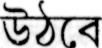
উঠবে
